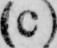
(c)
